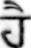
ਹੈ
